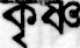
কৃষ্ণ
